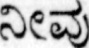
ನೀವು
